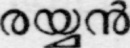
രയ്യന്‍
